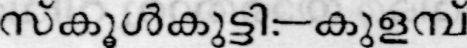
സ്കൂള്‍കുട്ടി:-കുളമ്പ്
